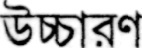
উচ্চারণ
